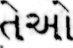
તેઓ
